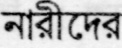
নারীদের
